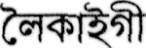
লৈকাইগী
